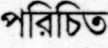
পরিচিত
